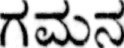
ಗಮನ
